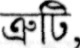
ত্রুটি,
